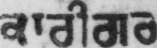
ਕਾਰੀਗਰ
